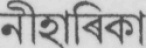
নীহাৰিকা
